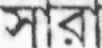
সারা
